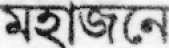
মহাজনে
